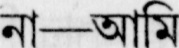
না-আমি
